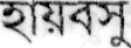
হায়বসু
